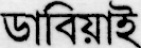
ডাবিয়াই
